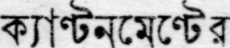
ক্যান্টনমেন্টের
